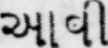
આવી
